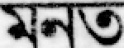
মনত
